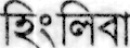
হিংলিবা
